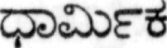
ಧಾರ್ಮಿಕ
